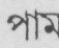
পাম
